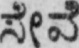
ಸೇವೆ
